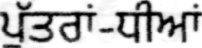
ਪੁੱਤਰਾਂ-ਧੀਆਂ
